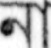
না
